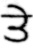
ਤੇ
